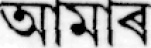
আমাৰ
